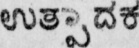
ಉತ್ಪಾದಕ
